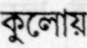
কুলোয়
